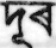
দূৰ
